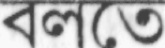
বলতে
